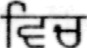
ਵਿਚ
